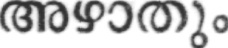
അഴാതും
